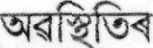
অৱস্থিতিৰ
